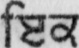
ਇਕ
